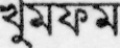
খুমফম
